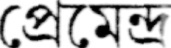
প্রেমেন্দ্র
